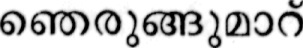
ഞെരുങ്ങുമാറ്
